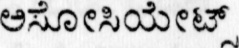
ಅಸೋಸಿಯೇಟ್ಸ್
